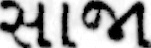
સાજા
